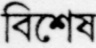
বিশেষ
